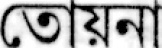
তোয়না
